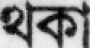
থকা
